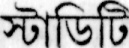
স্টাডিটি
